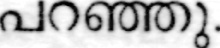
പറഞ്ഞു.
